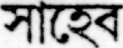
সাহেব
